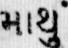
માથું
